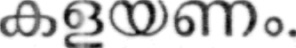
കളയണം.
